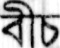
বীচ
